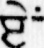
ਏਂ
